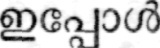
ഇപ്പോള്‍
